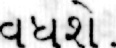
વધશે.
